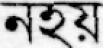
নহয়
